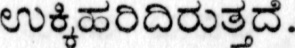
ಉಕ್ಕಿಹರಿದಿರುತ್ತದೆ.
